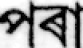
পৰা
